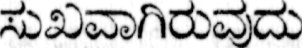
ಸುಖವಾಗಿರುವುದು
